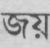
জয়
